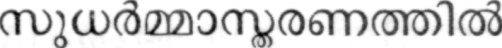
സുധര്‍മ്മാസ്തരണത്തില്‍
